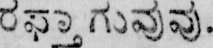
ರಫ್ತಾಗುವುವು.
